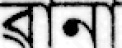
ৱানা
